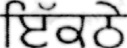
ਇੱਕਠੇ
